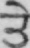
ਤੇ
